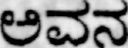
ಅವನ
